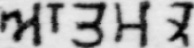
ਆਤਮਕ
